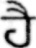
ਹੈ
